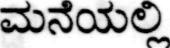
ಮನೆಯಲ್ಲಿ
